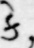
કે,
